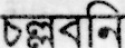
চল্লবনি
